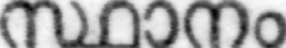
സ്ഥാനം
